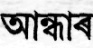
আন্ধাৰ
